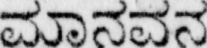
ಮಾನವನ
